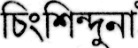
চিংশিন্দুনা
